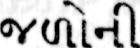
જળોની
